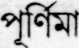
পূর্ণিমা
